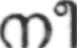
നീ
